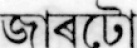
জাৰটো
